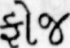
ફોજ
